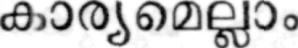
കാര്യമെല്ലാം
